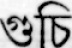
গুচি
